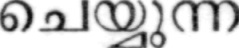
ചെയ്യുന്ന
